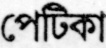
পেটিকা
